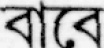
বাবে
